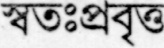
স্বতঃপ্রবৃত্ত
